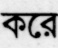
করে
